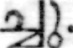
ച്ചു.
